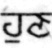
ਹੁਣ
